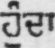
ਹੁੰਦਾ
